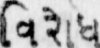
વિરોધ
